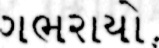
ગભરાયો.
